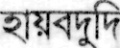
হায়বদুদি
